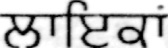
ਲਾਇਕਾਂ
